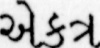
એકત્ર
